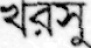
খরসু
